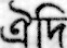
ঐদি
